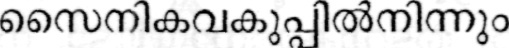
സൈനികവകുപ്പില്‍നിന്നും
